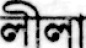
লীলা
